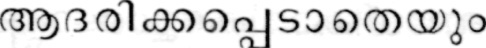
ആദരിക്കപ്പെടാതെയും
